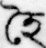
হৈ
